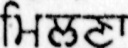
ਮਿਲਣਾ
